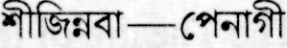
শীজিন্নবা-পেনাগী
